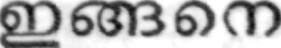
ഇങ്ങനെ
